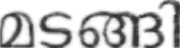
മടങ്ങി
